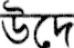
উদে
